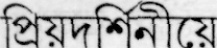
প্রিয়দৰ্শিনীয়ে
